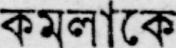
কমলাকে
